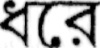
ধরে
